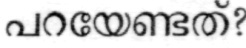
പറയേണ്ടത്?
